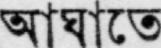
আঘাতে
